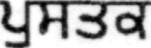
ਪੁਸਤਕ
